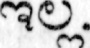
ಇಲ್ಲ.
